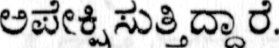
ಅಪೇಕ್ಷಿಸುತ್ತಿದ್ದಾರೆ.
